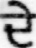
ਦੇ
